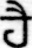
ਹੈ
